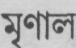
মৃণাল
